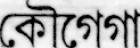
কৌগেগা
